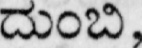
ದುಂಬಿ,
